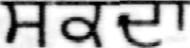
ਸਕਦਾ
